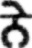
ਨੇ
